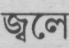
জ্বলে
